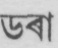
ডৰা
